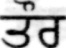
ਤੌਰ
